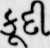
કૂદી
